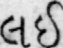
લઈ
